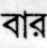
বার
